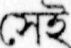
সেই
